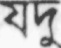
যদু
